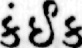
કંઈક
